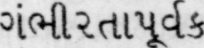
ગંભીરતાપૂર્વક
